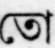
তো
